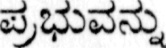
ಪ್ರಭುವನ್ನು
